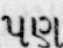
પણ
